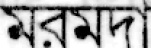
মরমদা
